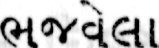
ભજવેલા
